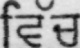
ਵਿੱਚ
